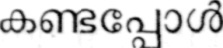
കണ്ടപ്പോള്‍
